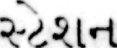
સ્ટેશન
